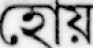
হোয়
